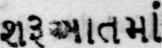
શરૂઆતમાં
